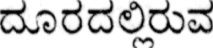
ದೂರದಲ್ಲಿರುವ
